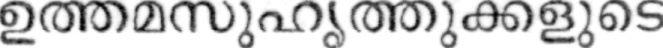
ഉത്തമസുഹൃത്തുക്കളുടെ
